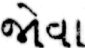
જોવા
